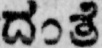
ದಂತೆ
